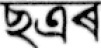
ছত্রৰ
